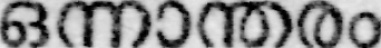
ഒന്നാന്തരം
